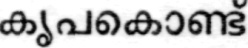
കൃപകൊണ്ട്
